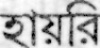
হায়রি
